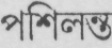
পশিলন্ত
